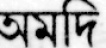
অমদি
